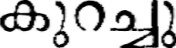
കുറച്ചു
